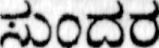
ಸುಂದರ
